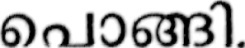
പൊങ്ങി.
